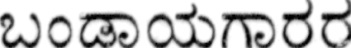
ಬಂಡಾಯಗಾರರ
